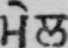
ਮੇਲ
